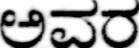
ಅವರ
